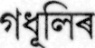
গধূলিৰ
